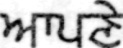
ਆਪਣੇ
